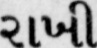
રાખી
